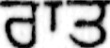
ਰਾਤ
